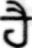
ਹੈ
